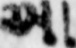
આ
